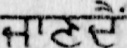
ਜਾਣਦੈਂ
